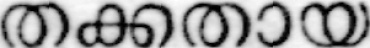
തക്കതായ
